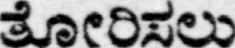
ತೋರಿಸಲು
